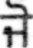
ਜੋ
